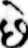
છે
